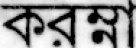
করম্না
